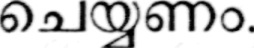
ചെയ്യണം.
